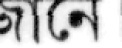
জানে
